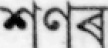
শণৰ
